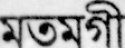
মতমগী
